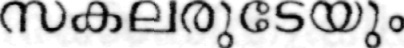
സകലരുടേയും
